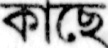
কাছে
